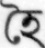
হৈ
